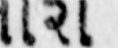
તારા
